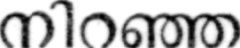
നിറഞ്ഞ
